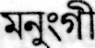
মনুংগী
